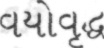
વયોવૃદ્ધ
